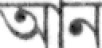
আন
